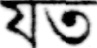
যত
